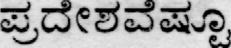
ಪ್ರದೇಶವೆಷ್ಟೂ
